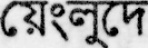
য়েংলুদে
